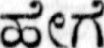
ಹೇಗೆ
